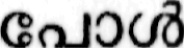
പോള്‍
